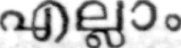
എല്ലാം
